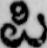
ಪಿ
